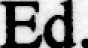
Ed.
